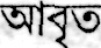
আবৃত
